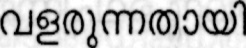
വളരുന്നതായി
